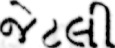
જેટલી
